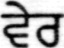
ਵੇਰ
